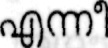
എന്നീ
